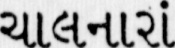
ચાલનારાં
